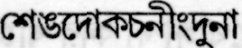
শেঙদোকচনীংদুনা
